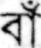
বাঁ
